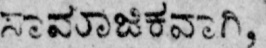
ಸಾಮಾಜಿಕವಾಗಿ,
